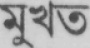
মুখত
